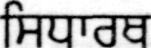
ਸਿਧਾਰਥ
